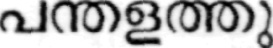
പന്തളത്തു
